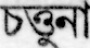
চত্তুনা
